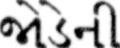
જોડેની
